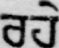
ਰਹੇ
